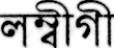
লম্বীগী
